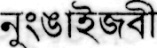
নুংঙাইজবী
